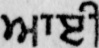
ਆਈ
